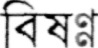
বিষণ্ণ
